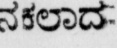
ನಕಲಾದ
